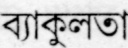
ব্যাকুলতা
